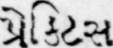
પ્રેક્ટિસ
